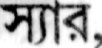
স্যার,
